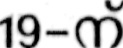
19-ന്
